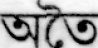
অতৈ
